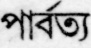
পার্বত্য
